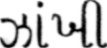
ઝાંખી
